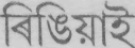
ৰিঙিয়াই
